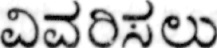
ವಿವರಿಸಲು
